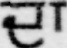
ਦਾ
